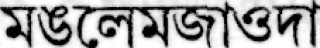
মঙলেমজাওদা
